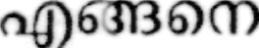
എങ്ങനെ
